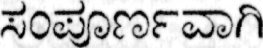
ಸಂಪೂರ್ಣವಾಗಿ
